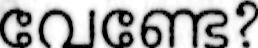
വേണ്ടേ?
